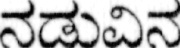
ನಡುವಿನ
